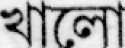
খালো
